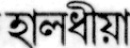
হালধীয়া
